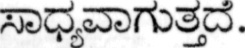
ಸಾಧ್ಯವಾಗುತ್ತದೆ.
